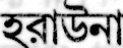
হরাউনা
